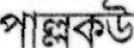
পাল্লকউ
